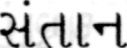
સંતાન
